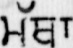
ਮੱਥਾ
